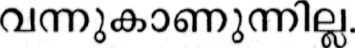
വന്നുകാണുന്നില്ല.
